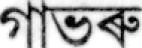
গাভৰু
